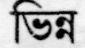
ভিন্ন
